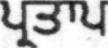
ਪ੍ਰਤਾਪ
